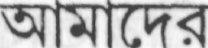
আমাদের
